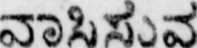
ವಾಸಿಸುವ
